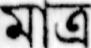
মাত্র
